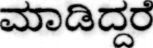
ಮಾಡಿದ್ದರೆ
